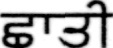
ਛਾਤੀ
